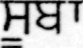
ਸੂਬਾ
